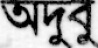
অদুবু
